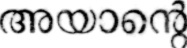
അയാന്റെ
